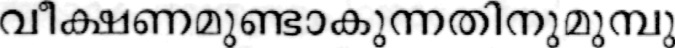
വീക്ഷണമുണ്ടാകുന്നതിനുമുമ്പു
